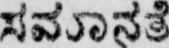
ಸಮಾನತೆ
